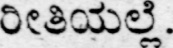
ರೀತಿಯಲ್ಲೆ.
